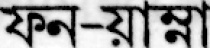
ফন-য়াম্না
